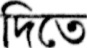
দিতে
